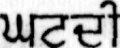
ਘਟਦੀ
